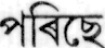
পৰিছে
